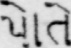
પોતે
